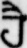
ਹੈ
